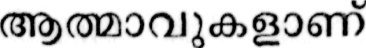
ആത്മാവുകളാണ്
